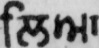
ਲਿਆ
